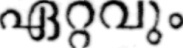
ഏറ്റവും
